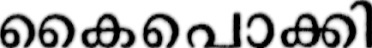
കൈപൊക്കി
